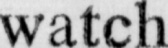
watch
